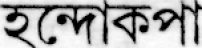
হন্দোকপা
